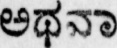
ಅಥವಾ
